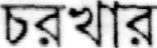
চরখার
